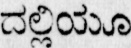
ದಲ್ಲಿಯೂ
